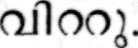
വിററു.
